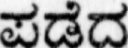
ಪಡೆದ
